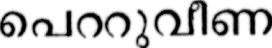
പെററുവീണ
